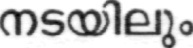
നടയിലും
